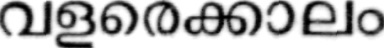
വളരെക്കാലം
